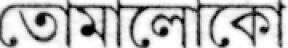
তোমালোকো
